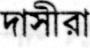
দাসীরা
